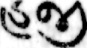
હજી
